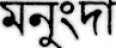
মনুংদা
